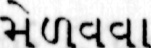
મેળવવા
